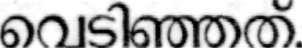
വെടിഞ്ഞത്.
